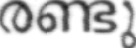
രണ്ടു
